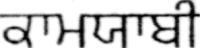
ਕਾਮਯਾਬੀ
